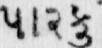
પારકું
